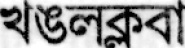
খঙলক্লবা
